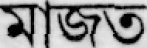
মাজত
